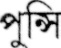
পুন্সি
